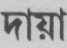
দায়া
